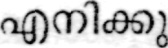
എനിക്കു
